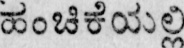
ಹಂಚಿಕೆಯಲ್ಲಿ
